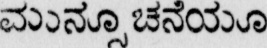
ಮುನ್ಸೂಚನೆಯೂ
